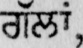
ਗੱਲਾਂ,
